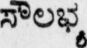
ಸೌಲಭ್ಯ
